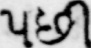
પછી
